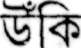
উঁকি
